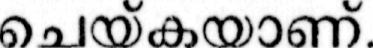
ചെയ്കയാണ്.
